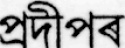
প্ৰদীপৰ
